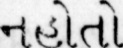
નહોતો
